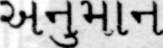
અનુમાન
